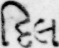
દિલ
